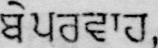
ਬੇਪਰਵਾਹ,
